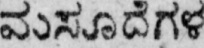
ಮಸೂದೆಗಳ
